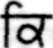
ਕਿ
